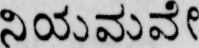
ನಿಯಮವೇ
